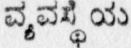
ವ್ಯವಸ್ಥೆಯ
